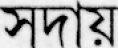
সদায়
